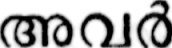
അവര്‍
